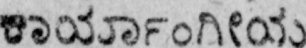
ಕಾರ್ಯಾಂಗೀಯ
